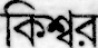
কিশ্বর
